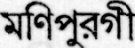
মণিপুরগী
